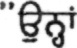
''ਉਨ੍ਹਾਂ
